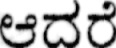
ಆದರೆ
